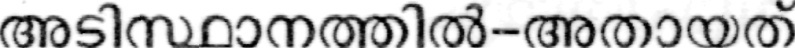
അടിസ്ഥാനത്തില്‍-അതായത്
